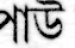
পাউ
